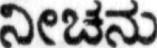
ನೀಚನು
